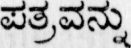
ಪತ್ರವನ್ನು
